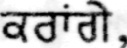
ਕਰਾਂਗੇ,
